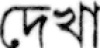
দেখা
